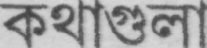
কথাগুলা
